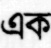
এক
